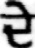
ਦੇ
